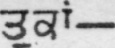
ਤੁਕਾਂ-
